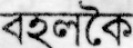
বহলকৈ
